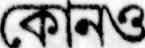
কোনও
